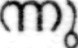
ന്നു
